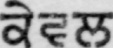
ਕੇਵਲ
